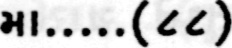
મા.....(૮૮)
